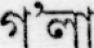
গ'লা
